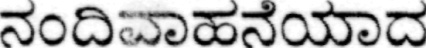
ನಂದಿವಾಹನೆಯಾದ
